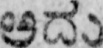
ಅದು
